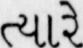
ત્યારે
